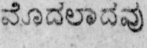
ಮೊದಲಾದವು
